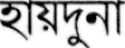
হায়দুনা
